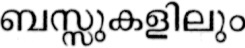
ബസ്സുകളിലും
